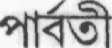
পার্বতী
